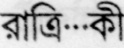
রাত্রি...কী
